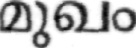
മുഖം
